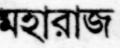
মহারাজ
